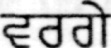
ਵਰਗੇ
